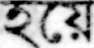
হয়ে
